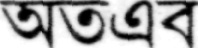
অতএব
